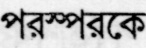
পরস্পরকে
